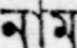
নাম
